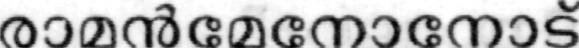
രാമന്‍മേനോനോട്
